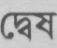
দ্বেষ
